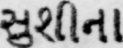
સુશીના
